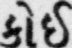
કોઈ
